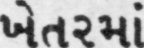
ખેતરમાં
